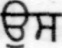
ਉਸ
